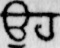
ਉਹ
